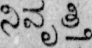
ನಿವೃತ್ತಿ
